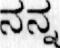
ನನ್ನ
